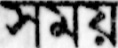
সময়
